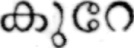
കുറേ
